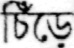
চিঁড়ে
